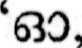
‘ഓ,
